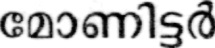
മോണിട്ടര്‍
